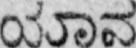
ಯಾವ
